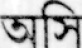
অসি
